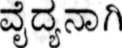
ವೈದ್ಯನಾಗಿ
